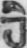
ਹੈ
